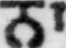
ਨਾ
